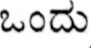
ಒಂದು
